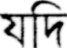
যদি
